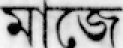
মাজে
